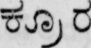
ಕ್ರೂರ
